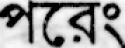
পরে
